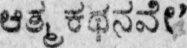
ಆತ್ಮಕಥನವೇ’
